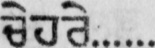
ਚੇਹਰੇ.......
